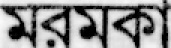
মরমকা
